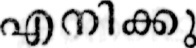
എനിക്കു
